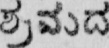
ಶ್ರಮದ
